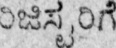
ರಿಜಿಸ್ಟರಿಗೆ
